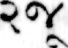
રજૂ
